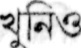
খুনিও
